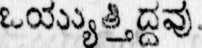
ಒಯ್ಯುತ್ತಿದ್ದವು.
